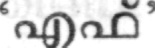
'എഫ്'
